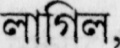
লাগিল,
